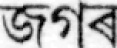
জগৰ
